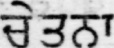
ਚੇਤਨਾ
